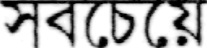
সবচেয়ে
